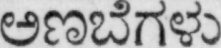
ಅಣಬೆಗಳು
